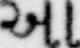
આ
